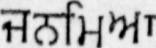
ਜਨਮਿਆ
